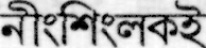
নীংশিংলকই
